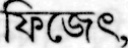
ফিজেৎ,
